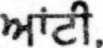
ਆਂਟੀ,
